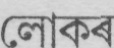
লোকৰ
